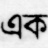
এক
